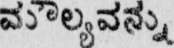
ಮೌಲ್ಯವನ್ನು
